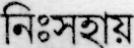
নিঃসহায়
